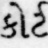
કોર્ટ
